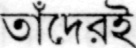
তাঁদেরই
